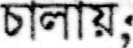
চালায়;
